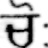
ਚੋ:
